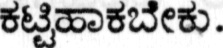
ಕಟ್ಟಿಹಾಕಬೇಕು.
